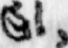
હા,
